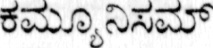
ಕಮ್ಯೂನಿಸಮ್
